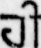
ਹੀ
